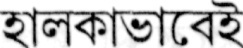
হালকাভাবেই
